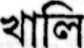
খালি
